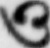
ও
